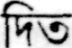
দিত
